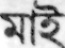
মাই
